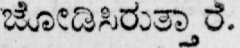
ಜೋಡಿಸಿರುತ್ತಾರೆ.
